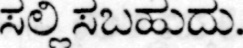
ಸಲ್ಲಿಸಬಹುದು.
